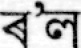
ৰ'ল
